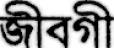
জীবগী
